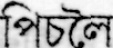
পিচলৈ
